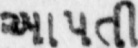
આપતી
